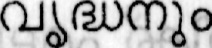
വൃദ്ധനും
